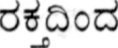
ರಕ್ತದಿಂದ
